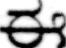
ಈ
